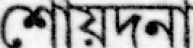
শোয়দনা
